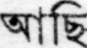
আছি
